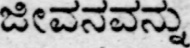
ಜೀವನವನ್ನು
